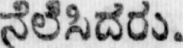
ನೆಲೆಸಿದರು.
